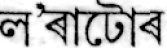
ল'ৰাটোৰ
